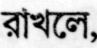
রাখলে,
